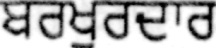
ਬਰਖੁਰਦਾਰ
